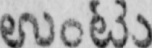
ಉಂಟು
